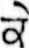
ਕੇ
